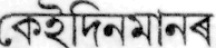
কেইদিনমানৰ
